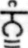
ਨੂੰ
